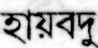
হায়বদু
